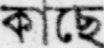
কাছে
